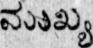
ಮುಖ್ಯ
